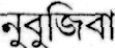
নুবুজিবা
